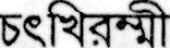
চৎখিরম্মী
